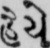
હૈયે
